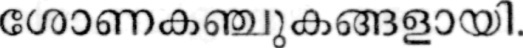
ശോണകഞ്ചുകങ്ങളായി.
